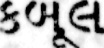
કબૂલ
